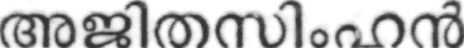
അജിതസിംഹന്‍
